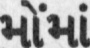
મોંમાં
